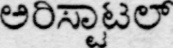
ಅರಿಸ್ಟಾಟಲ್
